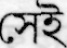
সেই
